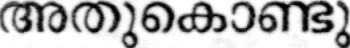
അതുകൊണ്ടു
